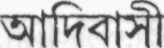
আদিবাসী
